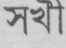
সখী
